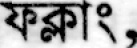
ফক্লাং,
